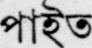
পাইত
